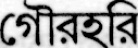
গৌরহরি
